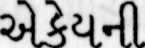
એકેયની
